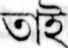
তাই
